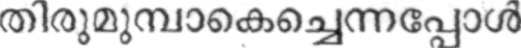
തിരുമുമ്പാകെച്ചെന്നപ്പോള്‍
